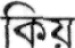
কিয়
